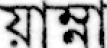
য়াম্না
